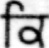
ਕਿ
